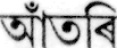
আঁতৰি
